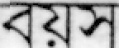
বয়স
